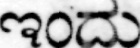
ಇಂದು
